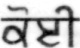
ਕੋਈ
